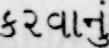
કરવાનું
